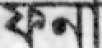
ফনা
